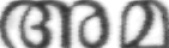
അമ
